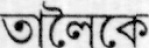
তালৈকে
